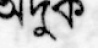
অদুক
